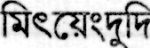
মিৎয়েংদুদি
